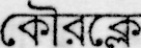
কৌরক্লে
